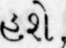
હશે,
